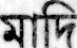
মাদি
